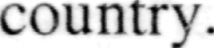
country.
